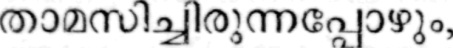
താമസിച്ചിരുന്നപ്പോഴും,
